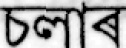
চলাৰ
